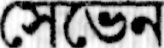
সেভেন
